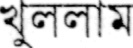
খুললাম
